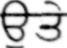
ਉਤੇ
